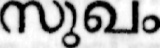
സുഖം
